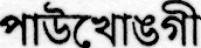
পাউখোঙগী
